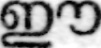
ഈ
